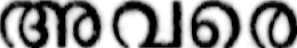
അവരെ
